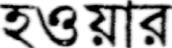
হওয়ার
